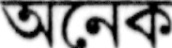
অনেক
